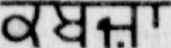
ਕਬਜ਼ਾ
